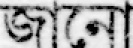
জানো
